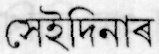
সেইদিনাৰ
